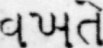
વખતે
